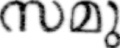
സമു
